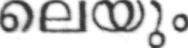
ലെയും
